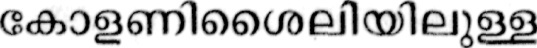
കോളണിശൈലിയിലുള്ള
